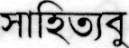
সাহিত্যবু
